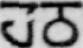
ਹਠ
